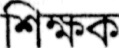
শিক্ষক
